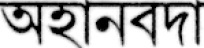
অহানবদা
